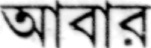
আবার
